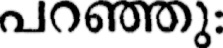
പറഞ്ഞു:
